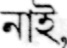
নাই,
